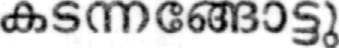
കടന്നങ്ങോട്ടു
